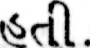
હતી.
